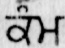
ਕੰਮ
